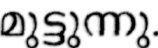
മുട്ടുന്നു.
